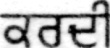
ਕਰਦੀ
